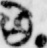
છે.
